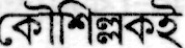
কৌশিল্লকই
